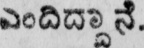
ಎಂದಿದ್ದಾನೆ.
